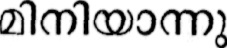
മിനിയാന്നു
